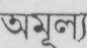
অমূল্য
